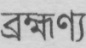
ব্ৰহ্মণ্য
